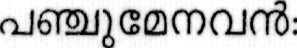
പഞ്ചുമേനവന്‍:
